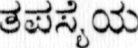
ತಪಸ್ಯೆಯ
